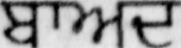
ਬਾਅਦ
